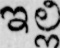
ಇಲ್ಲಿ
